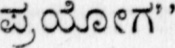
ಪ್ರಯೋಗ”
